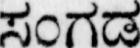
ಸಂಗಡ
